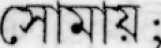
সোমায়;
